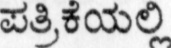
ಪತ್ರಿಕೆಯಲ್ಲಿ
